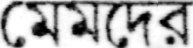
মেমদের
